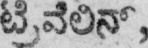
ಟ್ರೆವೆಲಿನ್,
